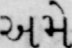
અમે
